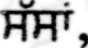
ਸੱਸਾਂ,
